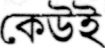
কেউই
